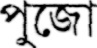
পুজো
